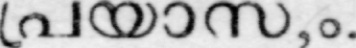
പ്രയാസ,ം.
